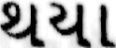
થયા
